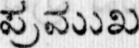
ಪ್ರಮುಖ
